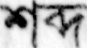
শব্দ
